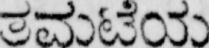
ತಮಟೆಯ
